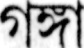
গঙ্গা
